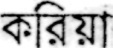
করিয়া
